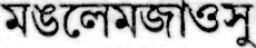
মঙলেমজাওসু
